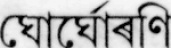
ঘোর্ঘোৰণি
